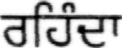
ਰਹਿੰਦਾ
